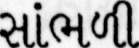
સાંભળી
